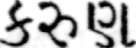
કરુણ
